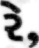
રે,
